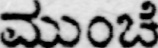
ಮುಂಚೆ
